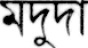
মদুদা
